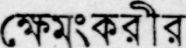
ক্ষেমংকরীর
